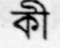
কী
